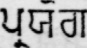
ਪ੍ਰਯੋਗ
